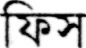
ফিস
